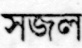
সজল
